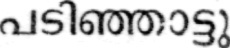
പടിഞ്ഞാട്ടു
